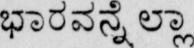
ಭಾರವನ್ನೆಲ್ಲಾ
